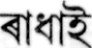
ৰাধাই
